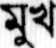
মুখ
